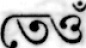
তেওঁ
